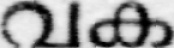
വക
